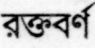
রক্তবর্ণ
